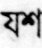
যশ
